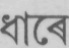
ধাৰে
